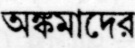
অঙ্কমাদের
